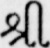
શ્રી
